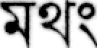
মথং
